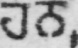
ਹਨ,
